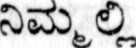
ನಿಮ್ಮಲ್ಲಿ
